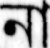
না
